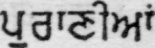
ਪੁਰਾਣੀਆਂ
